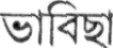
ভাবিছা
